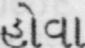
હોવા
